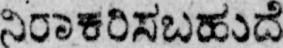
ನಿರಾಕರಿಸಬಹುದೆ
